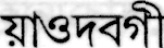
য়াওদবগী
